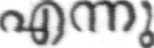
എന്നു
